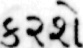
કરશે
